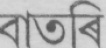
বাতৰি
